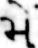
મેં
